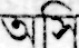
অসি
